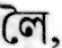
লৈ,
